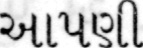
આપણી
